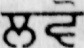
ਲਵੋ
